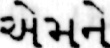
એમને
